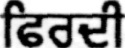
ਫਿਰਦੀ
